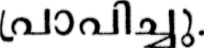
പ്രാപിച്ചു.
